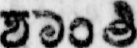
ಶಾಂತಿ
